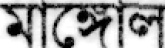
মাঙ্গোল
